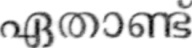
ഏതാണ്ട്
